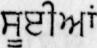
ਸੂਈਆਂ
